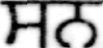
ਸਨ
